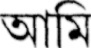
আমি
